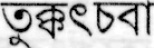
তুক্কৎচবা
